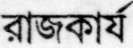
রাজকার্য
